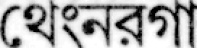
থেংনরগা
